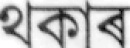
থকাৰ
